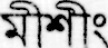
মীশীং
